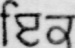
ਇਕ
